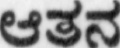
ಆತನ
